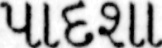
પાદશા
